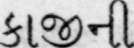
કાજીની
